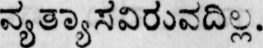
ವ್ಯತ್ಯಾಸವಿರುವದಿಲ್ಲ.
